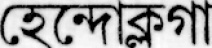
হেন্দোক্লগা
